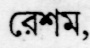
রেশম,
